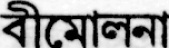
বীমোলনা
